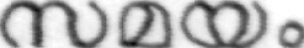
സമയം
